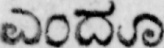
ಎಂದೂ
